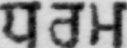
ਧਰਮ
